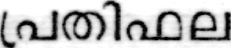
പ്രതിഫല
